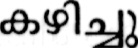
കഴിച്ചു
